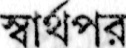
স্বার্থপর
